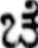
ಚೆ
